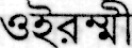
ওইরম্মী
